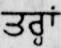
ਤਰ੍ਹਾਂ
